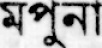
মপুনা
